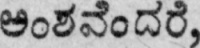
ಅಂಶವೆಂದರೆ,
